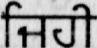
ਜਿਹੀ
